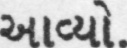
આવ્યો.
